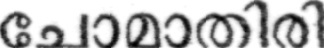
ചോമാതിരി
